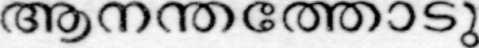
ആനന്തത്തോടു
